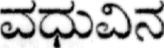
ವಧುವಿನ
